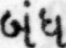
બંધ
